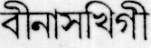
বীনাসখিগী
